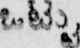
ಒಟ್ಟು
